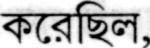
করেছিল,
